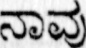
ನಾವು
